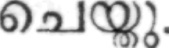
ചെയ്തു.
